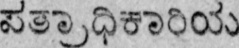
ಪತ್ರಾಧಿಕಾರಿಯ
